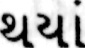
થયાં
